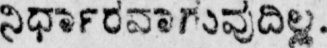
ನಿರ್ಧಾರವಾಗುವುದಿಲ್ಲ.
